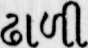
ઢાળી
